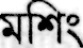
মশিং
